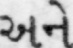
અને
